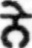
ਨੇ
